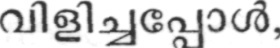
വിളിച്ചപ്പോള്‍,
